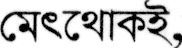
মেৎথোকই,
